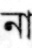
না
